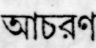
আচরণ
